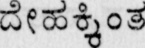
ದೇಹಕ್ಕಿಂತ
